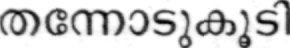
തന്നോടുകൂടി
